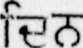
ਦਿਨ
